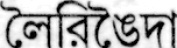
লৈরিঙৈদা
